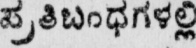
ಪ್ರತಿಬಂಧಗಳಲ್ಲಿ
